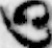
ও
